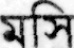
মসি
